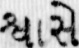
શ્વાસે
